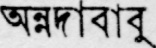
অন্নদাবাবু
